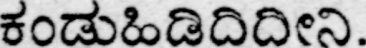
ಕಂಡುಹಿಡಿದಿದೀನಿ.
